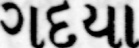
ગદયા
